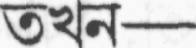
তখন–
